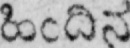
ಹಿಂದಿನ
